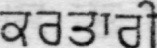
ਕਰਤਾਰੀ
